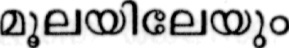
മൂലയിലേയും
